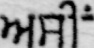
ਅਸੀਂ
